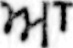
ਆ
